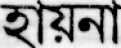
হায়না
